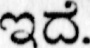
ಇದೆ.
